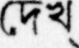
দেখ্
